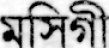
মসিগী
